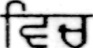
ਵਿਚ
